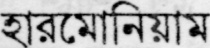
হারমোনিয়াম
